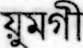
য়ুমগী
